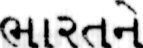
ભારતને
